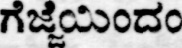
ಗೆಜ್ಜೆಯಿಂದಂ
